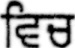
ਵਿਚ
